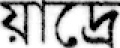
য়াদ্রে
